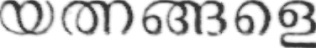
യത്നങ്ങളെ
